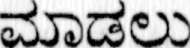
ಮಾಡಲು
